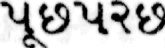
પૂછપરછ
